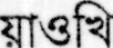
য়াওখি
